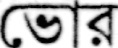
ভোর
